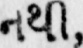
નથી,
